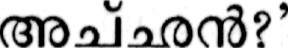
അച്‌ഛൻ?'
